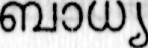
ബാധ്യ
